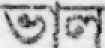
ভাল
